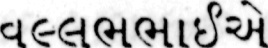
વલ્લભભાઈએ
